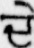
ਦੇ
